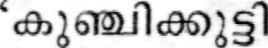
‘കുഞ്ചിക്കുട്ടി
